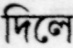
দিলে
